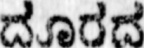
ದೂರದ
